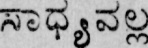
ಸಾಧ್ಯವಲ್ಲ
